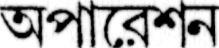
অপারেশন
